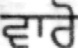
ਵਾਰੋ
